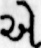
એ
